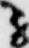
કે
